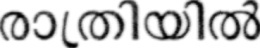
രാത്രിയില്‍
